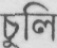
চুলি
